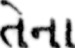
તેના
